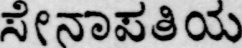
ಸೇನಾಪತಿಯ
